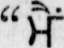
''ਮੈਂ
